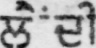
ਲੈਂਦੀ
